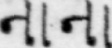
નાના
